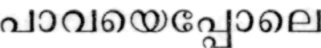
പാവയെപ്പോലെ
